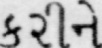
કરીને
